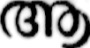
ആ
